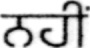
ਨਹੀਂ
